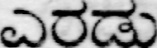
ಎರಡು
